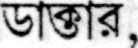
ডাক্তার,
